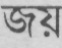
জয়
